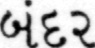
બંદર
